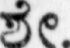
ಶೇ.
